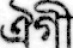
ঐগী
